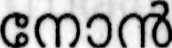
നോന്‍
